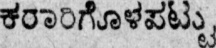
ಕರಾರಿಗೊಳಪಟ್ಟು
